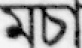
মচা
